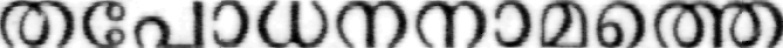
തപോധനനാമത്തെ
